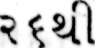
૨૬થી
